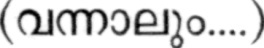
(വന്നാലും....)
